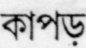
কাপড়
